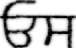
ਓਸ
